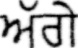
ਅੱਗੇ
